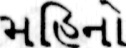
મહિનો
